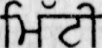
ਮਿੱਟੀ
